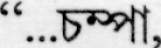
"...চম্পা,
